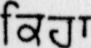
ਕਿਹਾ
